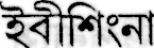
ইবীশিংনা
